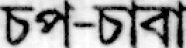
চপ-চাবা
